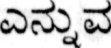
ಎನ್ನುವ
